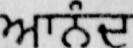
ਆਨੰਦ
